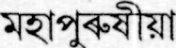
মহাপুৰুষীয়া
